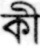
কী
